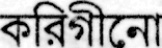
করিগীনো
